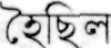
হৈছিল
